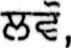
ਲਵੋ,
